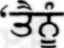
'ਤੈਨੂੰ
